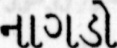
નાગડો
